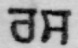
ਰਸ
